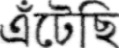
এঁটেছি
